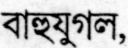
বাহুযুগল,
